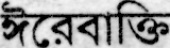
ঈরেবাক্তি
